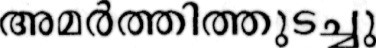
അമര്‍ത്തിത്തുടച്ചു
